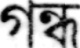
গন্ধ
